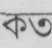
কত
